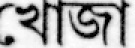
খোজা
